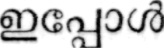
ഇപ്പോള്‍
